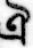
ঐ
